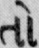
તો
